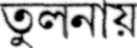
তুলনায়
